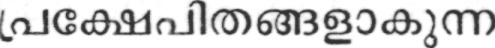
പ്രക്ഷേപിതങ്ങളാകുന്ന
